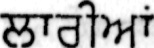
ਲਾਰੀਆਂ
